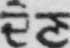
ਦੇਣ
